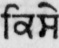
ਕਿਸੇ
